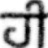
ਹੀ
